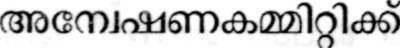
അന്വേഷണകമ്മിറ്റിക്ക്
